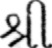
શ્રી
